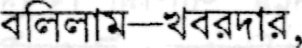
বলিলাম—খবরদার,
